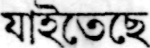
যাইতেছে
